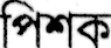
পিশক
